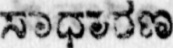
ಸಾಧಾರಣ
